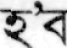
হ'ব
